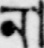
না
